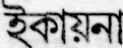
ইকায়না
